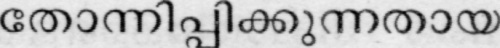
തോന്നിപ്പിക്കുന്നതായ
